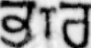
ਭਾਰ
